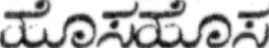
ಹೊಸಹೊಸ
